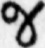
જ
